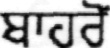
ਬਾਹਰੋਂ
